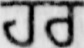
ਹਰ
